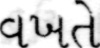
વખતે
